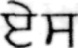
ਏਸ
